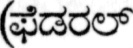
(ಫೆಡರಲ್
